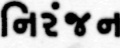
નિરંજન
